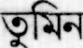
তুমিন
